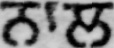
ਨਾਲ
